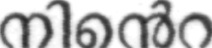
നിന്റെ
